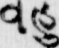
વહુ
